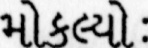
મોકલ્યો:
